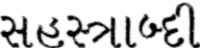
સહસ્ત્રાબ્દી
